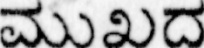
ಮುಖದ
